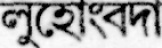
লুহোংবদা
